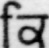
ਕਿ
